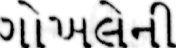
ગોખલેની
